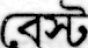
বেস্ট
